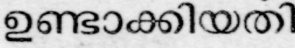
ഉണ്ടാക്കിയതി
